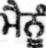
ਮੈਨੂੰ
